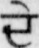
ਦੇ
